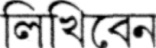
লিখিবেন
